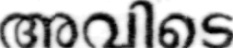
അവിടെ
